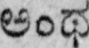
ಅಂಥ
